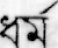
ধর্ম
